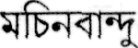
মচিনবান্দু
